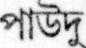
পাউদু
